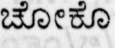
ಚೋಕೊ
